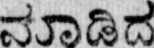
ಮಾಡಿದ
